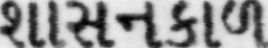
શાસનકાળ
